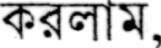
করলাম,
